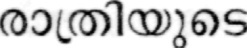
രാത്രിയുടെ
